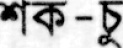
শক-চু
